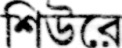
শিউরে
